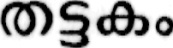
തട്ടകം
